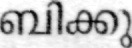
ബിക്കു
